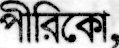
পীরিকো,
